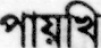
পায়খি
